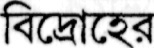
বিদ্রোহের
